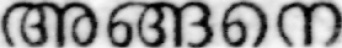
അങ്ങനെ
